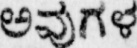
ಅವುಗಳ
